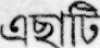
এছাটি
